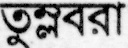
তুম্লবরা
